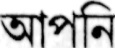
আপনি
